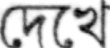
দেখে
